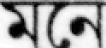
মনে
